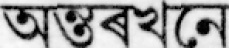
অন্তৰখনে
